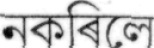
নকৰিলে
